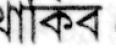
থাকিব
